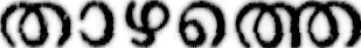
താഴത്തെ
